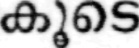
കൂടെ
